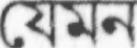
যেমন
